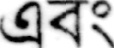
এবং
